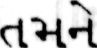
તમને
